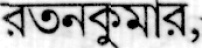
রতনকুমার,
